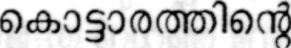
കൊട്ടാരത്തിന്റെ
